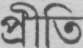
প্ৰীতি
